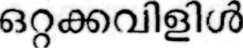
ഒറ്റക്കവിളിള്‍
